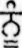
ਨੂੰ
